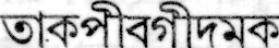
তাকপীবগীদমক
